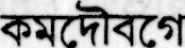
কমদৌবগে
